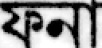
ফনা
